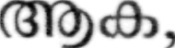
ആക,
